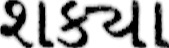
શક્યા
